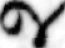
જ
